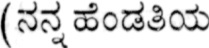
(ನನ್ನಹೆಂಡತಿಯ
